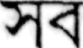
সব
